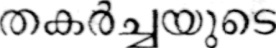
തകര്‍ച്ചയുടെ
